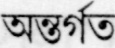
অন্তর্গত
